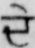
ਦੇ
